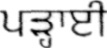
ਪੜ੍ਹਾਈ
